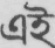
এই
